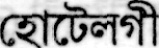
হোটেলগী
